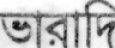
ভারাদি
